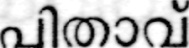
പിതാവ്
